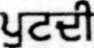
ਪੁਟਦੀ
